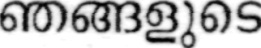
ഞങ്ങളുടെ
